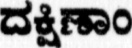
ದಕ್ಷಿಣಾ೦
